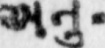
અનુ-
